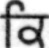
ਕਿ
